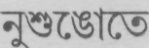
নুশুঙোতে
